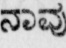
ನಾವು
